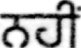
ਨਹੀਂ
